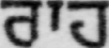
ਰਾਹ
